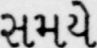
સમયે
